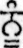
ਨੂੰ
